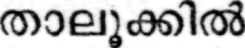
താലൂക്കില്‍
